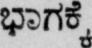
ಭಾಗಕ್ಕೆ
